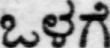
ಒಳಗೆ
